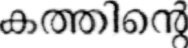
കത്തിന്റെ
